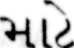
માટે
